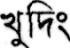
খুদিং
